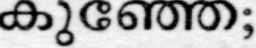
കുഞ്ഞേ;
